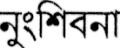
নুংশিবনা
